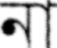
না
